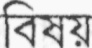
বিষয়
